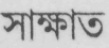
সাক্ষাত
